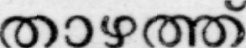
താഴത്ത്
